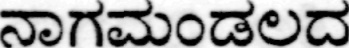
ನಾಗಮಂಡಲದ
